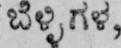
ಬೆಳ್ಳಿಗಳ,
